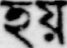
হয়
